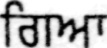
ਗਿਆ
